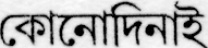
কোনোদিনাই
